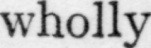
wholly
